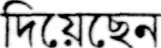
দিয়েছেন
